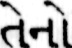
તેનો
